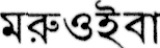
মরুওইবা
